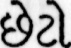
છેટો
